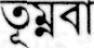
তূম্নবা
